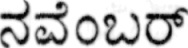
ನವೆಂಬರ್
